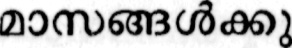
മാസങ്ങള്‍ക്കു
